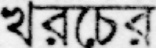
খরচের
